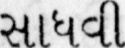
સાધવી
